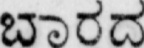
ಬಾರದ
